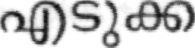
എടുക്ക
